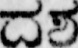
ದಶ
